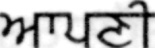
ਆਪਣੀ
